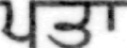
ਪਤਾ
